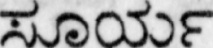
ಸೂರ್ಯ
